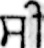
ਸੀ
